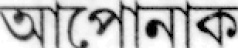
আপোনাক
